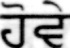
ਹੋਵੇ
